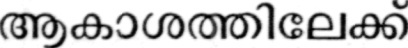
ആകാശത്തിലേക്ക്
